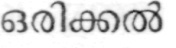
ഒരിക്കല്‍
